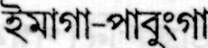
ইমাগা-পাবুংগা
